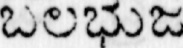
ಬಲಭುಜ
